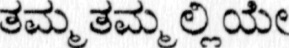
ತಮ್ಮತಮ್ಮಲ್ಲಿಯೇ
